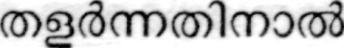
തളര്‍ന്നതിനാല്‍
